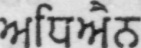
ਅਧਿਐਨ
